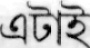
এটাই
